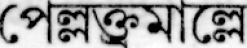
পেল্লক্ত্রমাল্লে
